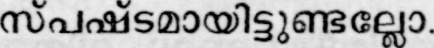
സ്പഷ്ടമായിട്ടുണ്ടല്ലോ.
